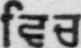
ਵਿਚ
